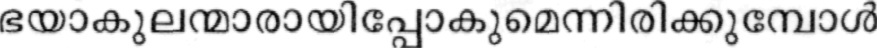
ഭയാകുലന്മാരായിപ്പോകുമെന്നിരിക്കുമ്പോള്‍
